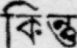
কিন্তু
